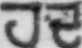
ਹਦ
